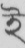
ই
